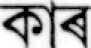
কাৰ
